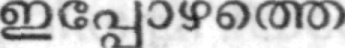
ഇപ്പോഴത്തെ
